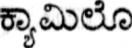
ಕ್ಯಾಮಿಲೊ
